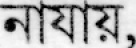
নাযায়,
